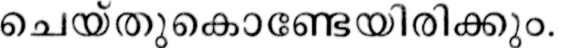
ചെയ്തുകൊണ്ടേയിരിക്കും.
